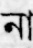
না
